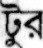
টুর
